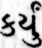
કર્યું
